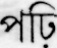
পঢ়ি
